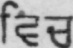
ਵਿਚ
